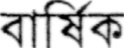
বার্ষিক
